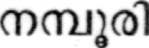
നമ്പൂരി
